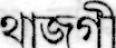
থাজগী
